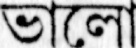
ভালো
